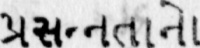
પ્રસન્નતાનો
